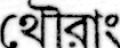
থৌরাং
